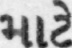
માટે
